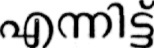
എന്നിട്ട്
